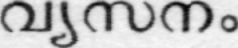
വ്യസനം
